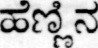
ಹೆಣ್ಣಿನ
